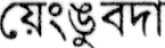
য়েংঙুবদা
